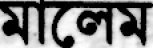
মালেম
